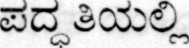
ಪದ್ಧತಿಯಲ್ಲಿ
